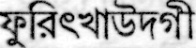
ফুরিৎখাউদগী
